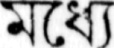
মধ্যে
